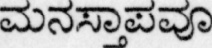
ಮನಸ್ತಾಪವೂ
